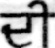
ਦੀ
